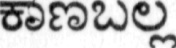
ಕಾಣಬಲ್ಲ
